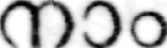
നാം
